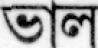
ভাল
